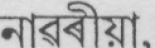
নাৱৰীয়া,
